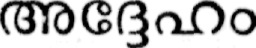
അദ്ദേഹം
